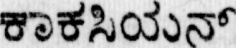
ಕಾಕಸಿಯನ್
